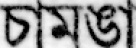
চামঙা
